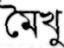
মৈখু
